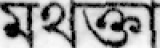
মথক্তা
